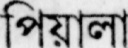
পিয়ালা
